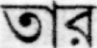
তার
